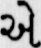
એ
